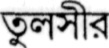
তুলসীর
